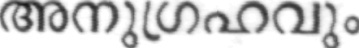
അനുഗ്രഹവും
